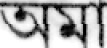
অমা
